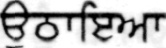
ਉਠਾਇਆ
